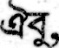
ঐবু,
